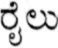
ರೈಲು
